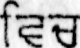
ਵਿਚ
